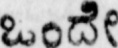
ಒಂದೇ
